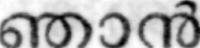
ഞാന്‍
